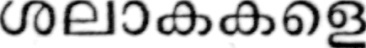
ശലാകകളെ
